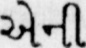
એની
